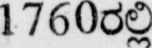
1760ರಲ್ಲಿ
